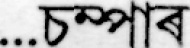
...চম্পাৰ
